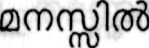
മനസ്സില്‍
